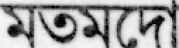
মতমদো
